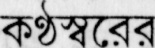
কণ্ঠস্বরের
